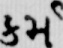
કર્મ
